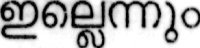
ഇല്ലെന്നും
